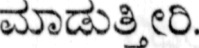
ಮಾಡುತ್ತೀರಿ.
